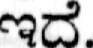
ಇದೆ.
